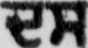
ਦਸ
